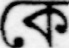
কে
